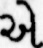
એ
